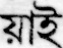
য়াই
